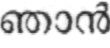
ഞാന്‍
